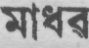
মাধৱ
